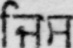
ਜਿਸ
